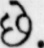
છે.
